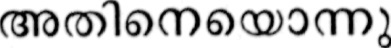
അതിനെയൊന്നു
